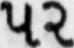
પર
